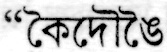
“কৈদৌঙৈ
